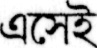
এসেই
